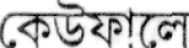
কেউফালে
